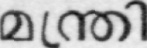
മന്ത്രി
